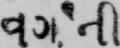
વર્ગની
